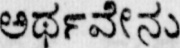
ಅರ್ಥವೇನು
